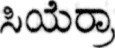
ಸಿಯೆರ್ರಾ
